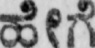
ಹೇಗೆ
